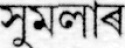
সুমলাৰ
